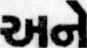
અને
